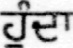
ਹੁੰਦਾ
